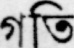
গতি
